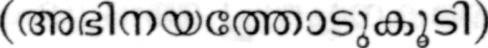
(അഭിനയത്തോടുകൂടി)
